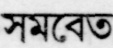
সমবেত
